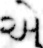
એ
